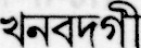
খনবদগী
